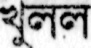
খুলল
